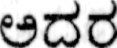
ಅದರ
